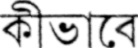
কীভাবে
